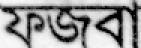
ফজবা
